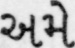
અમે
